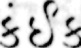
કોઈક
